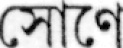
সোণে
